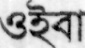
ওইবা
